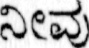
ನೀವು
